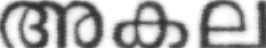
അകല
